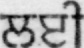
ਲਈ
